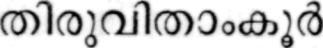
തിരുവിതാംകൂര്‍
